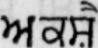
ਅਕਸ਼ੈ
